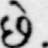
છે.
